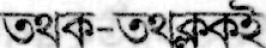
তথক-তথক্লকই
